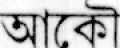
আকৌ
